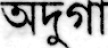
অদুগা
